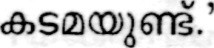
കടമയുണ്ട്.’
